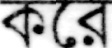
করে
